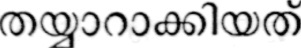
തയ്യാറാക്കിയത്
